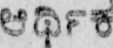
ಆರ್ಥಿಕ
